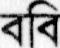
ববি
